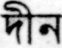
দীন
